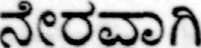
ನೇರವಾಗಿ
